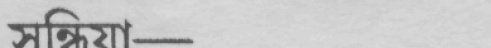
সন্ধিয়া-
